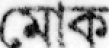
মোক
